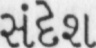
સંદેશ
